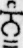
ਨੂੰ
